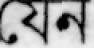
যেন
